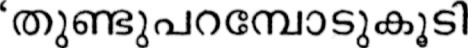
‘തുണ്ടുപറമ്പോടുകൂടി
